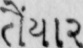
તૈયાર
